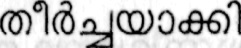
തീര്‍ച്ചയാക്കി
